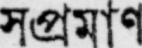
সপ্রমাণ
